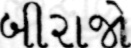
બીરાજો
